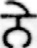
ਨੇ
